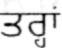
ਤਰ੍ਹਾਂ
